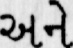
અને
